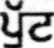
ਪੁੱਟ
